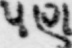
પણ
